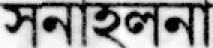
সনাহলনা
